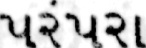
પરંપરા
